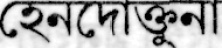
হেনদোক্তুনা
